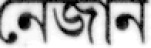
নেজান
